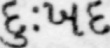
દુઃખદ
